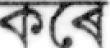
কৰে
